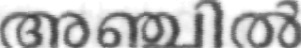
അഞ്ചില്‍
